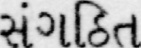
સંગઠિત
